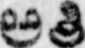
ಅತಿ
